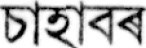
চাহাবৰ
